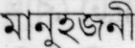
মানুহজনী
